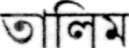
তালিম
